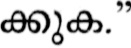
ക്കുക.”
